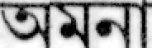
অমনা
